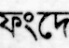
ফংদে
